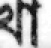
খা
